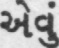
એવું
